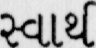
સ્વાર્થ
